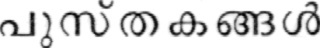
പുസ്തകങ്ങള്‍
